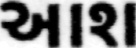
આશ
